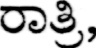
ರಾತ್ರಿ,
